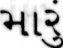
મારું
